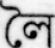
লৈ
